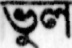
ভুল
